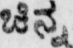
ಚಿನ್ನ
